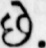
છે.
